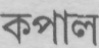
কপাল
